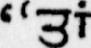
''ਤਾਂ
